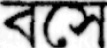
বসে
